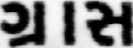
ગ્રાસ
